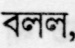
বলল,
